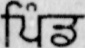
ਪਿੰਡ
